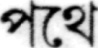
পথে
